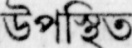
উপস্থিত
